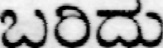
ಬರಿದು
